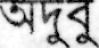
অদুবু
